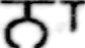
ਨਾ
